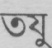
তযু
